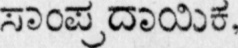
ಸಾಂಪ್ರದಾಯಿಕ,
